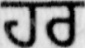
ਹਰ
